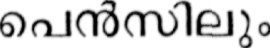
പെന്‍സിലും
